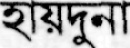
হায়দুনা
